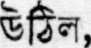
উঠিল,
